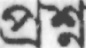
প্রশ্ন
